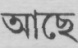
আছে
